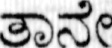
ತಾನೇ
